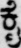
ಕೈ
